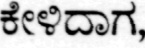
ಕೇಳಿದಾಗ,
